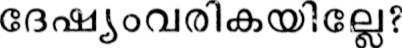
ദേഷ്യംവരികയില്ലേ?
